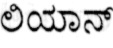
ಲಿಯಾನ್
